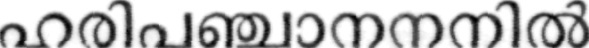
ഹരിപഞ്ചാനനനില്‍
